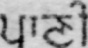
ਪਾਣੀ
